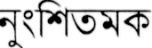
নুংশিতমক
